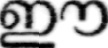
ഈ
